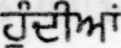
ਹੁੰਦੀਆਂ
